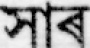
সাৰ
